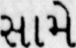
સામે
